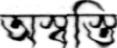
অস্বস্তি
